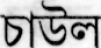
চাউল
